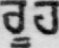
ਰੂਹ
